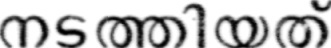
നടത്തിയത്
